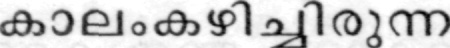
കാലംകഴിച്ചിരുന്ന
